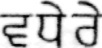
ਵਧੇਰੇ
